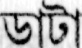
ডাটা
